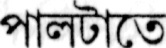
পালটাতে
